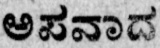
ಅಪವಾದ
